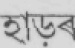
হাড়ৰ
